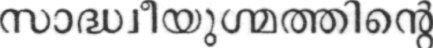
സാദ്ധ്വീയുഗ്മത്തിന്റെ
